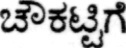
ಚೌಕಟ್ಟಿಗೆ
